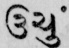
ઉચું
